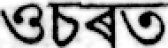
ওচৰত
